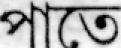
পাতে
